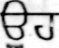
ਉਹ
